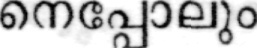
നെപ്പോലും
